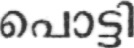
പൊട്ടി
